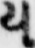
ય
